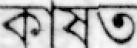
কাষত
